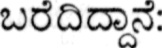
ಬರೆದಿದ್ದಾನೆ:
